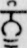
ਨੂੰ
